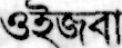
ওইজবা
